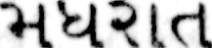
મધરાત
